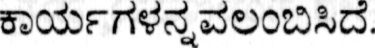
ಕಾರ್ಯಗಳನ್ನವಲಂಬಿಸಿದೆ.
